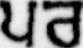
ਪਰ
